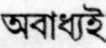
অবাধ্যই
